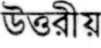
উত্তরীয়
